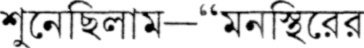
শুনেছিলাম–“মনস্থিরের
